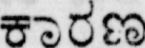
ಕಾರಣ
